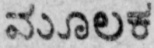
ಮೂಲಕ
